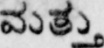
ಮತ್ತು
